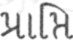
પ્રાપ્તિ
